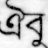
ঐবু
